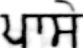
ਪਾਸੇ
